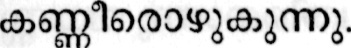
കണ്ണീരൊഴുകുന്നു.
